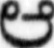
ಆ
